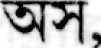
অস,
